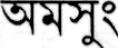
অমসুং
